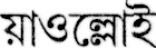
য়াওল্লোই
